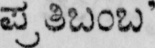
ಪ್ರತಿಬಂಬ’
